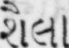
શૈલા
